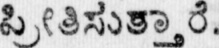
ಪ್ರೀತಿಸುತ್ತಾರೆ.
